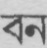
বন
